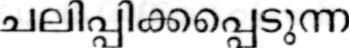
ചലിപ്പിക്കപ്പെടുന്ന
